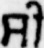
ਸੀ
